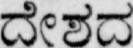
ದೇಶದ
